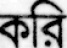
করি
